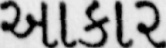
આકાર
